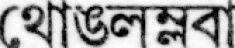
থোঙলম্লবা
